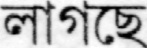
লাগছে
